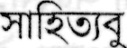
সাহিত্যবু
